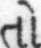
તો
